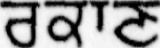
ਰਕਾਣ
